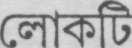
লোকটি
